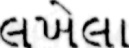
લખેલા
